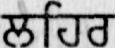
ਲਹਿਰ
